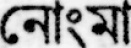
নোংমা
